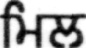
ਮਿਲ
